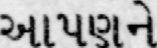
આપણને
